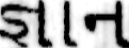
જ્ઞાન
